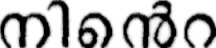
നിന്റെ
